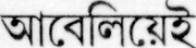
আবেলিয়েই
